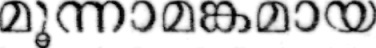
മൂന്നാമങ്കമായ
